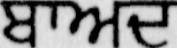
ਬਾਅਦ
